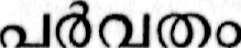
പര്‍വതം
